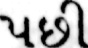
પછી
